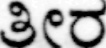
ತೀರ
